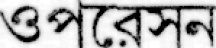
ওপরেসন
